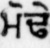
ਮੋਢੇ
